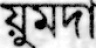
য়ুমদা
